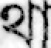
থা
